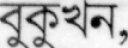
বুকুখন,
